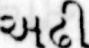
અઢી
